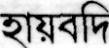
হায়বদি
